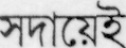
সদায়েই
